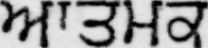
ਆਤਮਕ
